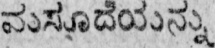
ಮಸೂದೆಯನ್ನು
